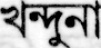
খন্দুনা
